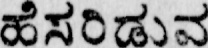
ಹೆಸರಿಡುವ
